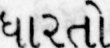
ધારતો
